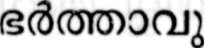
ഭര്‍ത്താവു
